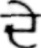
ਦੇ
